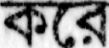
করে
